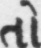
તો
